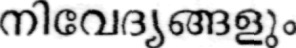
നിവേദ്യങ്ങളും
